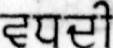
ਵਧਦੀ
